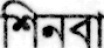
শিনবা
